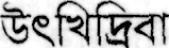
উৎখিদ্রিবা
